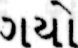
ગયો
